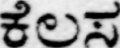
ಕೆಲಸ
